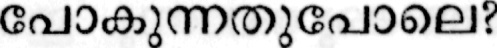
പോകുന്നതുപോലെ?
